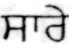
ਸਾਰੇ
